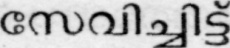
സേവിച്ചിട്ട്
